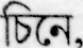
চিনে,
